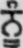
ਨੂੰ
